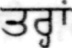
ਤਰ੍ਹਾਂ
